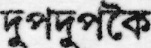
দুপদুপকৈ
